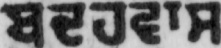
ਬਦਹਵਾਸ
